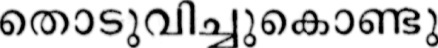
തൊടുവിച്ചുകൊണ്ടു
